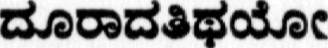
ದೂರಾದತಿಥಯೋ
